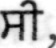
ਸੀ,
